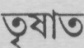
তৃষাত
